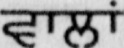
ਵਾਲਾਂ
